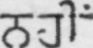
ਨਹੀਂ
